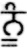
ਨੂੰ
